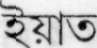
ইয়াত
